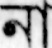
না
